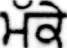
ਮੱਕੇ
